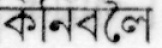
কিনিবলৈ
